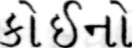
કોઈનો
